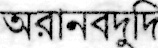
অরানবদুদি
